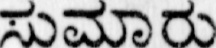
ಸುಮಾರು
